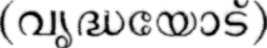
(വൃദ്ധയോട്)
